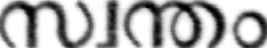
സ്വന്തം
